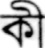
কী
